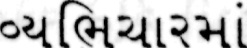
વ્યભિચારમાં
